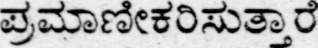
ಪ್ರಮಾಣೀಕರಿಸುತ್ತಾರೆ
